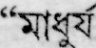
"মাধুর্য
